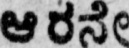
ಆರನೇ
